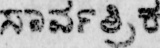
ಸಾರ್ವತ್ರಿಕ
